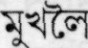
মুখলৈ
